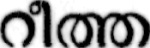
റീത്ത
